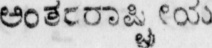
ಅಂತರರಾಷ್ಟ್ರೀಯ
